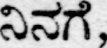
ನಿನಗೆ,
